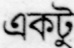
একটু
